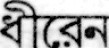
ধীরেন
